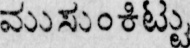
ಮುಸುಂಕಿಟ್ಟು
